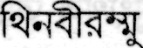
থিনবীরম্মু
